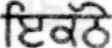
ਇਕੱਠੇ
